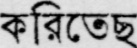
করিতেছ
